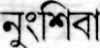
নুংশিবা
